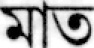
মাত
